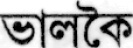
ভালকৈ
